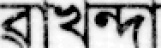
ৱাখন্দা
